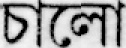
চালো
